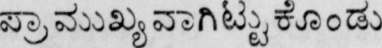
ಪ್ರಾಮುಖ್ಯವಾಗಿಟ್ಟುಕೊಂಡು
